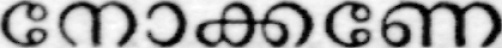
നോക്കണേ
